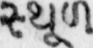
સ્થૂળ
